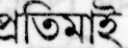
প্রতিমাই
